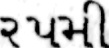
૨૫મી
